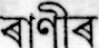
ৰাণীৰ
